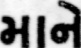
માને
